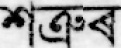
শত্রুৰ
